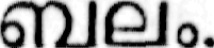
ബലം.
